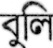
বুলি
